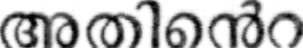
അതിന്റെ
